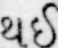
થઈ
